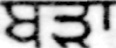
ਬੜਾ
